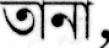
তানা,
